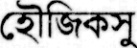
হৌজিকসু
